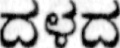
ದಳದ
